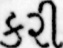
કરી
